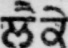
ਲੈਕੇ
